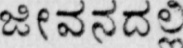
ಜೀವನದಲ್ಲಿ
